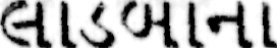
લાડબાના
